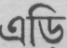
এড়ি
